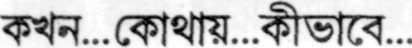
কখন...কোথায়...কীভাবে...
